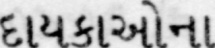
દાયકાઓના
